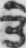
ਤੇ
